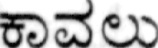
ಕಾವಲು
